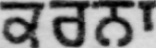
ਕਰਨਾ
